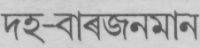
দহ-বাৰজনমান
